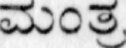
ಮಂತ್ರ
